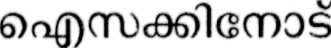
ഐസക്കിനോട്
